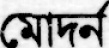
মোর্দন
